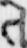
તે
